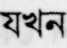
যখন
